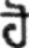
ਹੋ
